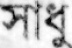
সাধু
